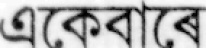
একেবাৰে
